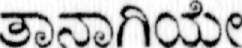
ತಾನಾಗಿಯೇ
